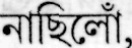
নাছিলোঁ,
